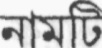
নামটি
